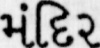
મંદિર
